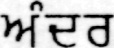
ਅੰਦਰ
